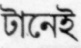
টানেই
